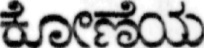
ಕೋಣೆಯ
